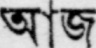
আজ
